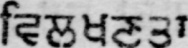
ਵਿਲਖਣਤਾ
